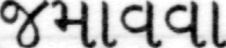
જમાવવા
